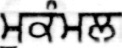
ਮੁਕੰਮਲ
